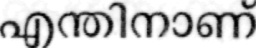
എന്തിനാണ്
